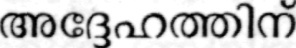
അദ്ദേഹത്തിന്
